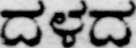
ದಳದ
